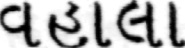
વહાલા
